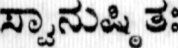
ಸ್ವಾನುಷ್ಠಿತಃ
